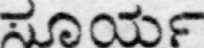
ಸೂರ್ಯ
